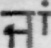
ਜਾਂ
